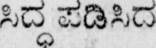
ಸಿದ್ಧಪಡಿಸಿದ
